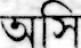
অসি
